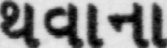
થવાના
